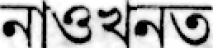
নাওখনত
